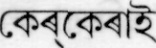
কেৰ্‌কেৰাই
